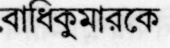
বোধিকুমারকে
